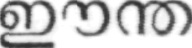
ഈന്ത
